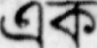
এক
